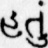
હતું
